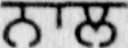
ਨਾਲ
